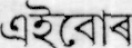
এইবোৰ
